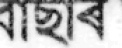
বাছাৰ
